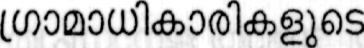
ഗ്രാമാധികാരികളുടെ
